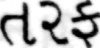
તરફ
